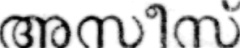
അസീസ്
